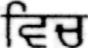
ਵਿਚ
